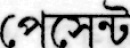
পেসেন্ট
